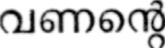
വണന്റെ
